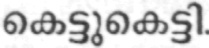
കെട്ടുകെട്ടി.
